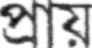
প্রায়
